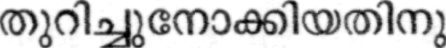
തുറിച്ചുനോക്കിയതിനു
